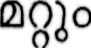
മറ്റും
